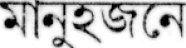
মানুহজনে
